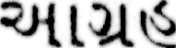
આગ્રહ
